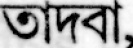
তাদবা,
